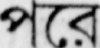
পরে
